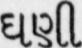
ઘણી
